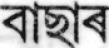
বাছাৰ
